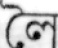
লৈ
